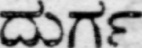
ದುರ್ಗ
